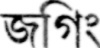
জগিং
